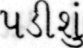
પડીશું
